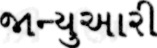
જાન્યુઆરી
